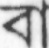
বা
